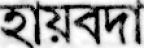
হায়বদা
